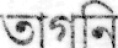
তাগনি
